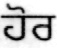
ਹੋਰ
